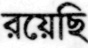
রয়েছি
